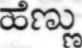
ಹೆಣ್ಣು
